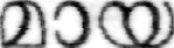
മായ
